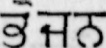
ਭੋਜਨ
